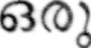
ഒരു
